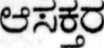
ಆಸಕ್ತರ
